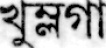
খুম্লগা
